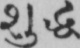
શુદ્ધ
